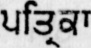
ਪਤ੍ਰਿਕਾ
